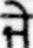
ਜੇ
